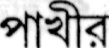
পাখীর
